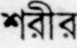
শরীর
